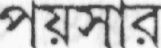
পয়সার
